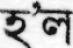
হ'ল
